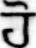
ਹੋ
